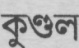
কুণ্ডল
